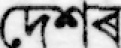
দেশৰ
